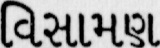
વિસામણ
